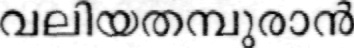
വലിയതമ്പുരാന്‍
